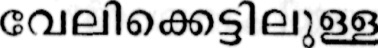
വേലിക്കെട്ടിലുള്ള
